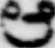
ಆ
